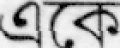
একে
